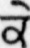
ਕੇ
